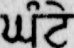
ਘੰਟੇ
